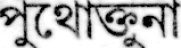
পুথোক্তুনা
